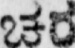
ಚರ
